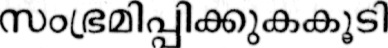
സംഭ്രമിപ്പിക്കുകകൂടി
